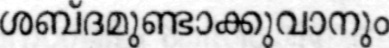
ശബ്ദമുണ്ടാക്കുവാനും
